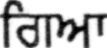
ਗਿਆ
